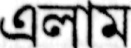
এলাম
